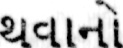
થવાનો
